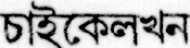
চাইকেলখন
